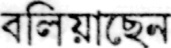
বলিয়াছেন
